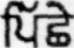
ਪਿੱਛੇ
